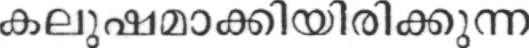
കലുഷമാക്കിയിരിക്കുന്ന
